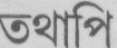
তথাপি
